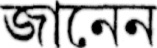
জানেন
